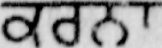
ਕਰਨਾ
